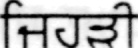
ਜਿਹੜੀ
